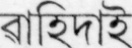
ৱাহিদাই
